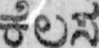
ಕೆಲಸ
